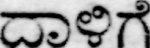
ದಾಳಿಗೆ
